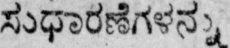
ಸುಧಾರಣೆಗಳನ್ನು
